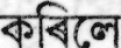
কৰিলে
